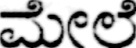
ಮೇಲೆ
